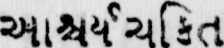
આશ્ચર્યચકિત
